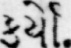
કર્યો.
